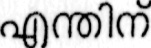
എന്തിന്
